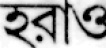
হরাও
